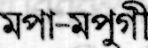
মপা-মপুগী
